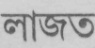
লাজত
